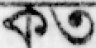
কত
